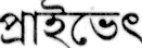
প্রাইভেৎ
